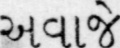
અવાજે
